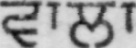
ਵਾਲਾ
